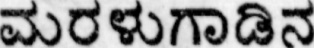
ಮರಳುಗಾಡಿನ
